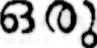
ഒരു
